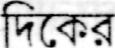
দিকের
